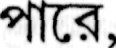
পারে,
